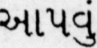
આપવું
